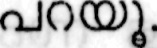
പറയു.
